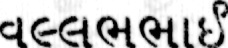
વલ્લભભાઈ
